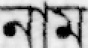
নাম
